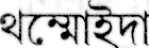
থম্মোইদা
